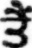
ਤੈਂ
